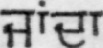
ਜਾਂਦਾ
